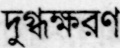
দুগ্ধক্ষরণ
